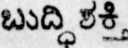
ಬುದ್ಧಿಶಕ್ತಿ
